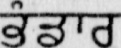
ਭੰਡਾਰ
